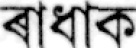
ৰাধাক
